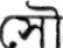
সৌ
